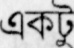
একটু
